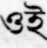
ওই
